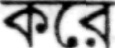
করে
